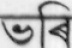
ভৰি
